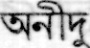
অনীদু
